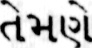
તેમણે
